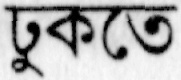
ঢুকতে
